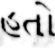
હતો
